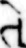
તે
